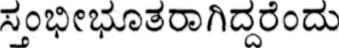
ಸ್ತಂಭೀಭೂತರಾಗಿದ್ದರೆಂದು
